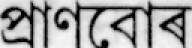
প্রাণবোৰ
